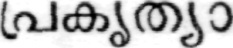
പ്രകൃത്യാ
